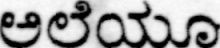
ಅಲೆಯೂ
